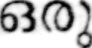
ഒരു
